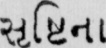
સૃષ્ટિના
